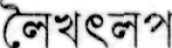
লৈখৎলপ
